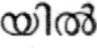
യില്‍
